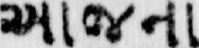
આજના
